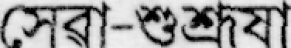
সেৱা-শুশ্রূষা
